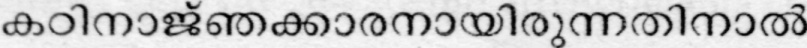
കിനാജ്ഞക്കാരനായിരുന്നതിനാല്‍
